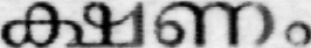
ക്ഷണം
